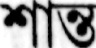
শান্ত
